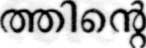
ത്തിന്റെ
